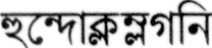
হুন্দোক্লম্লগনি
